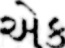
એક
